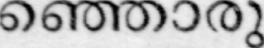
ഞ്ഞൊരു
